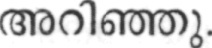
അറിഞ്ഞു.
